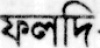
ফলদি
